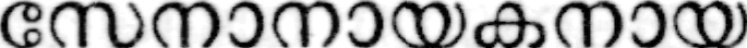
സേനാനായകനായ
